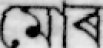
মোৰ
